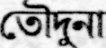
তৌদুনা
